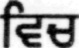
ਵਿਚ
